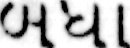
બધા
